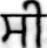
ਸੀ
